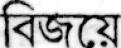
বিজয়ে
